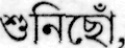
শুনিছোঁ,
